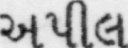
અપીલ
